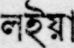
লইয়া
